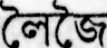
লৈজৈ
